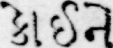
કોઈને
